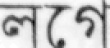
লগে
